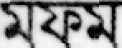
মফম
